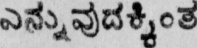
ಎನ್ನುವುದಕ್ಕಿಂತ
